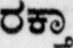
ರಕ್ತಾ
